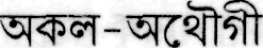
অকল-অথৌগী
